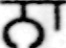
ਨਾ
